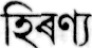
হিৰণ্য
